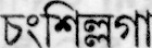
চংশিল্লগা
